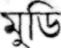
মুডি
